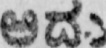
ಅದು
